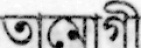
তামোগী
